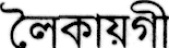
লৈকায়গী
